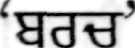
'ਬਰਚ'
